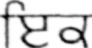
ਇਕ
